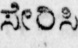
ಸೇರಿಸಿ
